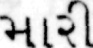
મારી
